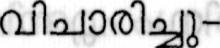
വിചാരിച്ചു-
